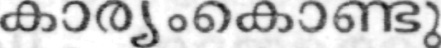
കാര്യംകൊണ്ടു
